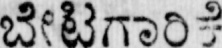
ಬೇಟಿಗಾರಿಕೆ
